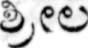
ಶ್ರೀಲ
